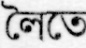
লৈতে
